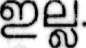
ഇല്ല.
